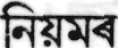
নিয়মৰ
